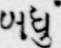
બધું
